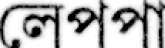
লেপপা
